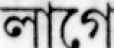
লাগে
